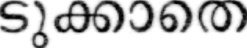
ടുക്കാതെ
